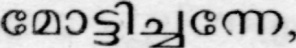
മോട്ടിച്ചന്നേ,
